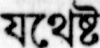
যথেষ্ট
